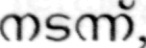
നടന്ന്,
